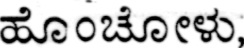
ಹೊಂಚೋಳು,
